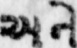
અને
